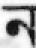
ন
